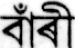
বাঁৰী
